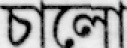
চালো
